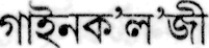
গাইনক'ল'জী
